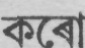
কৰো
